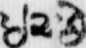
ઇચ્છે
